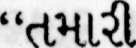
"તમારી
